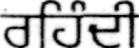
ਰਹਿੰਦੀ
